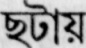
ছটায়
